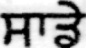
ਸਾਡੇ
